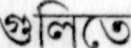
গুলিতে
